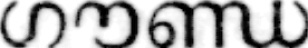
ഗൗണ്ഡ
